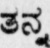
ತನ್ನ
